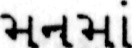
મનમાં
